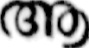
ആ
